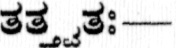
ತತ್ತ್ವತಃ-
